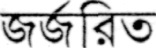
জর্জরিত
